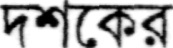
দশকের
